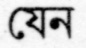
যেন
